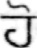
ਹੋ
